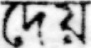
দেয়
